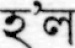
হ'ল
